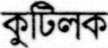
কুটিলক
